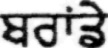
ਬਰਾਂਡੇ
